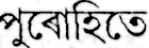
পুৰোহিতে
